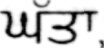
ਘੱਤਾ,
